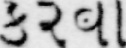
કરવા
